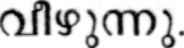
വീഴുന്നു.
